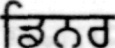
ਡਿਨਰ
